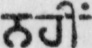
ਨਹੀਂ
